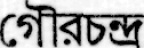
গৌরচন্দ্র
